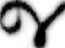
જ
